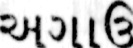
અગાઉ
